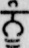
ਨੂੰ
